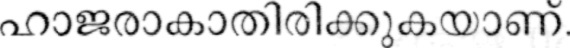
ഹാജരാകാതിരിക്കുകയാണ്.
